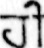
ਹੀ
